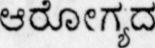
ಆರೋಗ್ಯದ
